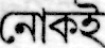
নোকই
